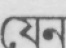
যেন
